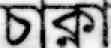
চাক্না
